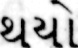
થયો
